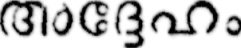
അദ്ദേഹം
